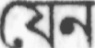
যেন
